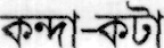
কন্দা-কটা
